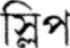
স্লিপ
